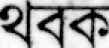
থবক
